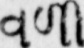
વળી
